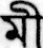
মী
